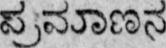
ಪ್ರಮಾಣನ
